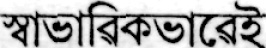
স্বাভাৱিকভাৱেই
